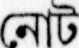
নোট
